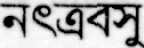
নৎত্রবসু
